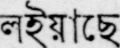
লইয়াছে
